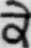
ਕੇ
